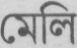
মেলি
